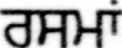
ਰਸਮਾਂ
